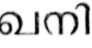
ഖനി
